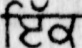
ਇੱਕ
